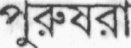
পুরুষরা
